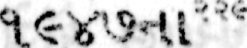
૧૯૪૭ના૨૨૯
